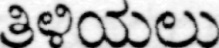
ತಿಳಿಯಲು
